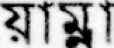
য়াম্না
